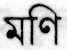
মণি
